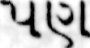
પણ
